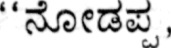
"ನೋಡಪ್ಪ,
